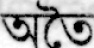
অতৈ
